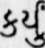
કર્યું
